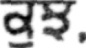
ਕੁਝ,
